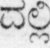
ದಲ್ಲಿ
